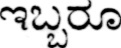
ಇಬ್ಬರೂ
